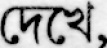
দেখে,
